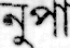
নুপা
